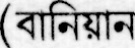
(বানিয়ান
